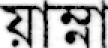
য়াম্না
